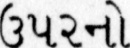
ઉપરનો
